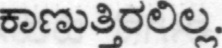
ಕಾಣುತ್ತಿರಲಿಲ್ಲ.
